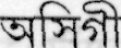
অসিগী
